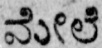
ಮೇಲೆ
